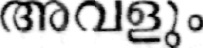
അവളും
